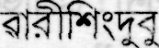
ৱারীশিংদুবু
